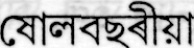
ষোলবছৰীয়া
